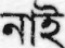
নাই
